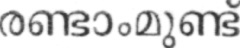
രണ്ടാംമുണ്ട്
